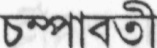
চম্পাবতী
